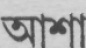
আশা
